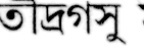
তৌদ্রগসু
